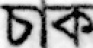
চাক
